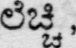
ಲೆಚ್ಚಿ,
